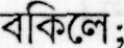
বকিলে;
